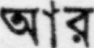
আর
